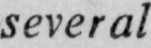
several
